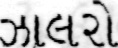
ઝાલરો
